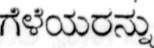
ಗೆಳೆಯರನ್ನು
